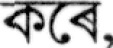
কৰে,
